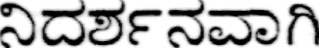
ನಿದರ್ಶನವಾಗಿ
